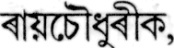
ৰায়চৌধুৰীক,
